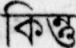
কিন্তু
